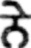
ਨੇ
